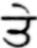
ਤੇ
